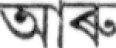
আৰু
